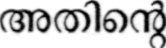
അതിന്റെ
